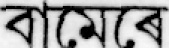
বামেৰে
